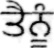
ਤੈਨੂੰ
